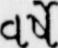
વર્ષે
